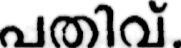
പതിവ്.
